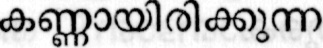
കണ്ണായിരിക്കുന്ന
